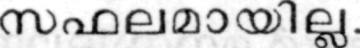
സഫലമായില്ല.
